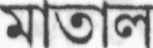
মাতাল
